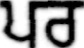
ਪਰ
